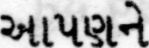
આપણને
